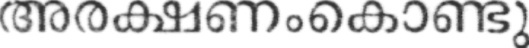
അരക്ഷണംകൊണ്ടു
